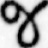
જ
